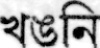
খঙনি
